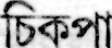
চিকপা
